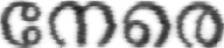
നേരെ
